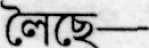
লৈছে-
